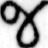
જ
